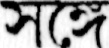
সঙ্গে
